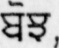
ਬੋਝ,
